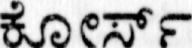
ಕೋರ್ಸ್
